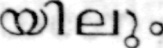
യിലും
